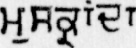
ਮੁਸਕ੍ਰਾਂਦਾ
